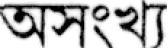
অসংখ্য
